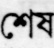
শেষ
